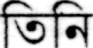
তিনি
